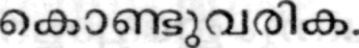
കൊണ്ടുവരിക.
